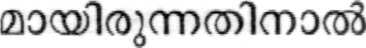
മായിരുന്നതിനാല്‍
